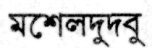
মশেলদুদবু
